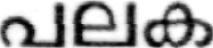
പലക
